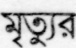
মৃত্যুর
